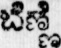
ಬೆಣ್ಣೆ
